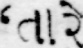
'તારે
